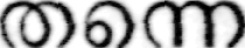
തന്നെ
